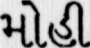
મોહી
